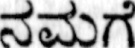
ನಮಗೆ
